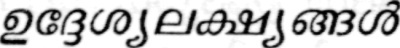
ഉദ്ദേശ്യലക്ഷ്യങ്ങള്‍
